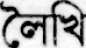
লৈখি
